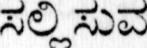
ಸಲ್ಲಿಸುವ
